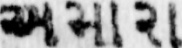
અમારા
